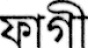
ফাগী
